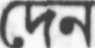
দেন
